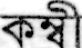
কম্বী
